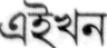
এইখন
